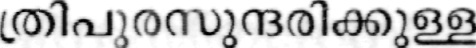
ത്രിപുരസുന്ദരിക്കുള്ള
